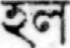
হল
